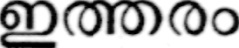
ഇത്തരം
